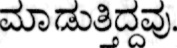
ಮಾಡುತ್ತಿದ್ದವು.
